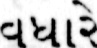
વધારે
